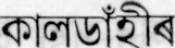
কালডাঁহীৰ
